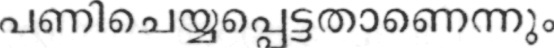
പണിചെയ്യപ്പെട്ടതാണെന്നും
